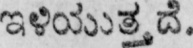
ಇಳಿಯುತ್ತದೆ.
